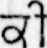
ਕੀ
